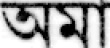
অমা
